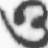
ও
